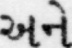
અને
